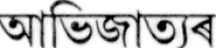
আভিজাত্যৰ
